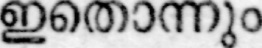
ഇതൊന്നും
